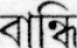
বান্ধি
